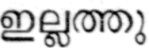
ഇല്ലത്തു
